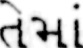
તેમાં
